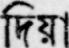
দিয়া
